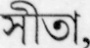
সীতা,
